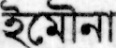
ইমৌনা
